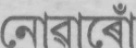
নোৱাৰোঁ
